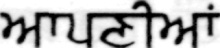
ਆਪਣੀਆਂ
